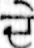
ਦੇ
